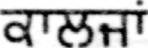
ਕਾਲਜਾਂ
